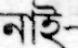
নাই-
